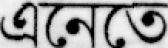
এনেতে
